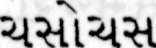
ચસોચસ
